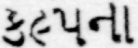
કલ્પના
